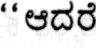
"ಆದರೆ
